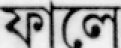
ফালে
